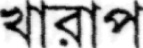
খারাপ
